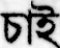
চাই
